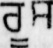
ਰੂਸ
